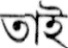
তাই
